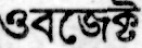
ওবজেক্টল
